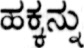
ಹಕ್ಕನ್ನು
